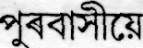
পুৰবাসীয়ে
